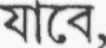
যাবে,
